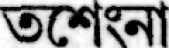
তশেংনা
